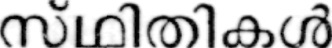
സ്ഥിതികള്‍
